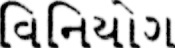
વિનિયોગ
